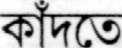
কাঁদতে
